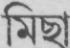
মিছা
